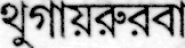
থুগায়রুরবা
